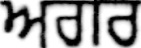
ਅਗਰ
